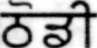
ਠੋਡੀ
